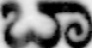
ಬಾ
